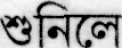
শুনিলে
